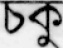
চকু
